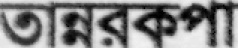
তান্নরকপা
